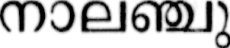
നാലഞ്ചു
